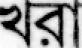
খরা
